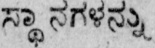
ಸ್ಥಾನಗಳನ್ನು
